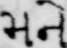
મને
